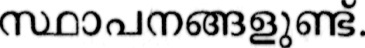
സ്ഥാപനങ്ങളുണ്ട്.
